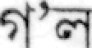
গ'ল
